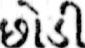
છોડી
